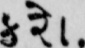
કરો.
